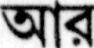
আর
